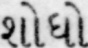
શોધો
